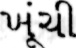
ખૂંચી
